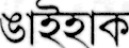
ঙাইহাক
